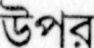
উপর
